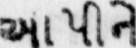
આપીને
